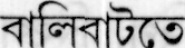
বালিবাটতে
